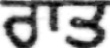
ਰਾਤ
